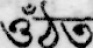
ওঁঠত
